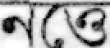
নত্তে
